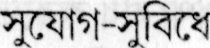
সুযোগ-সুবিধে
